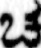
ಚ
